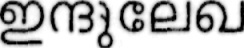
ഇന്ദുലേഖ
